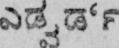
ಎಡ್ವರ್ಡ್
